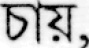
চায়,
